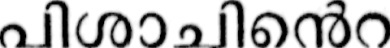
പിശാചിന്റെ
